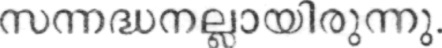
സന്നദ്ധനല്ലായിരുന്നു.
